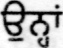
ਉਨ੍ਹਾਂ
